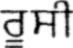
ਰੂਸੀ
